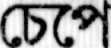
চেপে
